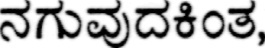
ನಗುವುದಕಿಂತ,
